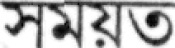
সময়ত
